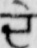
ਦੇ
